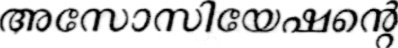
അസോസിയേഷന്റെ
